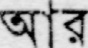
আর
